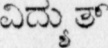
ವಿದ್ಯುತ್
